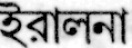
ইরালনা
